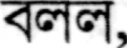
বলল,
